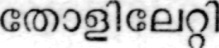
തോളിലേറ്റി
